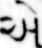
એ
